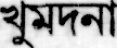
খুমদনা
